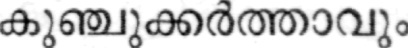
കുഞ്ചുക്കര്‍ത്താവും
